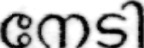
നേടി
